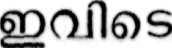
ഇവിടെ
